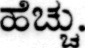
ಹೆಚ್ಚು.
